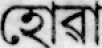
হোৱা
